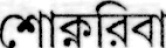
শোক্নরিবা
